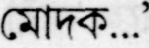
মোদক...’
